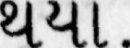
થયા.
